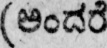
(ಅಂದರೆ
